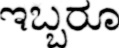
ಇಬ್ಬರೂ
